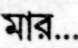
মার...
